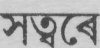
সত্বৰে
